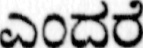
ಎಂದರೆ
